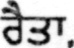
ਰੈਤਾ,
